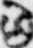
છે
